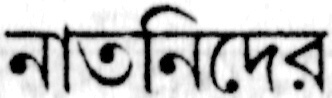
নাতনিদের
